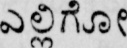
ಎಲ್ಲಿಗೋ
